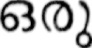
ഒരു
